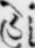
હોં
